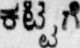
ಕಟ್ಟಿಗೆ
